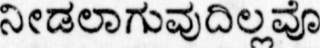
ನೀಡಲಾಗುವುದಿಲ್ಲವೊ
